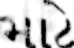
માટે
